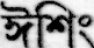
ঈশিং
